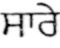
ਸਾਰੇ
